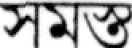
সমস্ত
